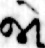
જો
